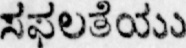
ಸಫಲತೆಯು
